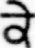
ਕੇ
